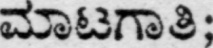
ಮಾಟಗಾತಿ;
